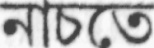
নাচতে
